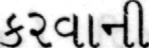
કરવાની
